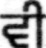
ਵੀ
